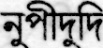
নুপীদুদি
